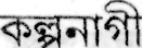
কল্পনাগী
